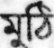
মুঠি
